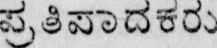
ಪ್ರತಿಪಾದಕರು
